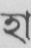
হা
